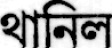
থানিল
